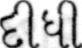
દીધી
